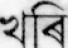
খৰি
